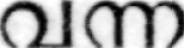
വന്ന
